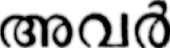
അവര്‍
